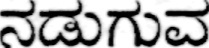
ನಡುಗುವ
